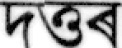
দত্তৰ
